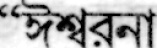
“ঈশ্বরনা
